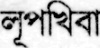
লূপখিবা
